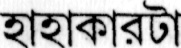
হাহাকারটা
